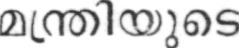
മന്ത്രിയുടെ
